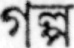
গল্প
